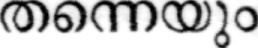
തന്നെയും
